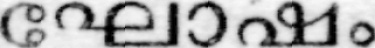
ഘോഷം
